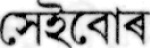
সেইবোৰ
